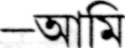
-আমি
